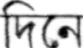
দিনে
